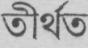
তীৰ্থত
